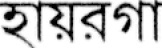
হায়রগা
